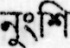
নুংশি
